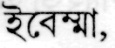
ইবেম্মা,
